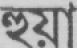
হুয়া
